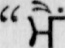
''ਮੈਂ
